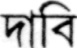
দাবি
